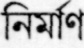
নির্মাণ
